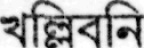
খল্লিবনি
